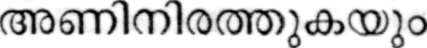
അണിനിരത്തുകയും
